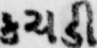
કચડી
